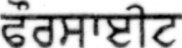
ਫੌਰਸਾਈਟ
